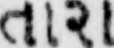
તારા
